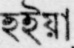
হইয়া
